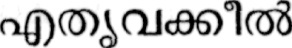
എതൃവക്കീല്‍
